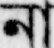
না
